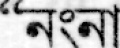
“নংনা
